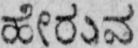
ಹೇರುವ
